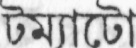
টম্যাটো
